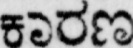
ಕಾರಣ
